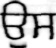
ਉਸ
